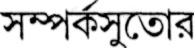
সম্পর্কসুতোর
